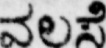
ವಲಸೆ
